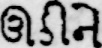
ઊઠીને
